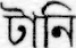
টানি
